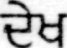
ਦੇਖ
